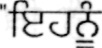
''ਇਹਨੂੰ
